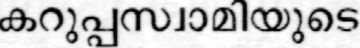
കറുപ്പസ്വാമിയുടെ
